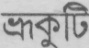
ভ্ৰূকুটি
